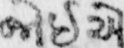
જોઈએ
